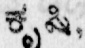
ಕೃಷಿ,
